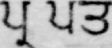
ਪ੍ਰਪਤ
